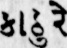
કાઠુરે
